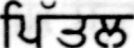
ਪਿੱਤਲ
